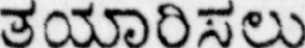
ತಯಾರಿಸಲು
